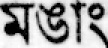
মঙাং
